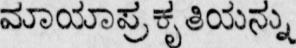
ಮಾಯಾಪ್ರಕೃತಿಯನ್ನು
